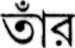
তাঁর
